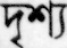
দৃশ্য
